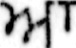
ਆ
